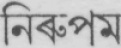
নিৰুপম
